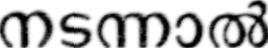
നടന്നാല്‍
